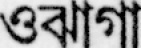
ওঝাগা
